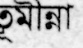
তূমীন্না
